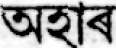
অহাৰ
